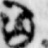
છે.
